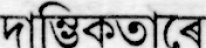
দাম্ভিকতাৰে
